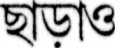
ছাড়াও
